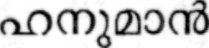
ഹനുമാന്‍
